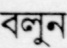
বলুন
